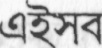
এইসব
